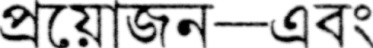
প্রয়োজন–এবং
